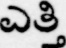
ಎತ್ತಿ
